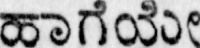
ಹಾಗೆಯೇ
